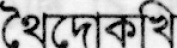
থৈদোকখি
